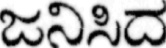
ಜನಿಸಿದ
